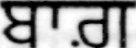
ਬਾਗ਼
